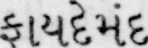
ફાયદેમંદ
